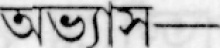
অভ্যাস-
